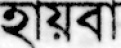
হায়বা
